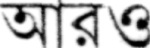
আরও
